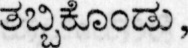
ತಬ್ಬಿಕೊಂಡು,
